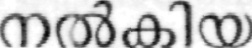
നല്‍കിയ
